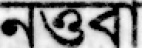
নত্তবা
